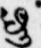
છું
